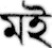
মই
